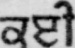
ਕਈ
